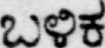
ಬಳಿಕ
